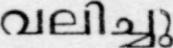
വലിച്ചു
